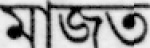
মাজত
